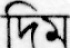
দিম
